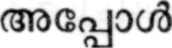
അപ്പോള്‍
